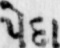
પેદા
